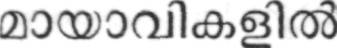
മായാവികളില്‍
